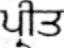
ਪ੍ਰੀਤ
